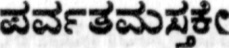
ಪರ್ವತಮಸ್ತಕೇ
